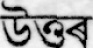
উত্তৰ
